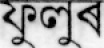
ফুলুৰ
